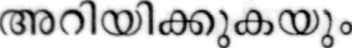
അറിയിക്കുകയും
